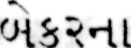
બેકરના
